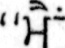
''ਮੈਂ
